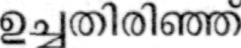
ഉച്ചതിരിഞ്ഞ്
